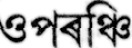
ওপৰঞ্চি
